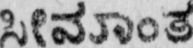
ಸೀಮಾಂತ
